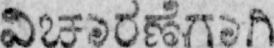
ವಿಚಾರಣೆಗಾಗಿ
